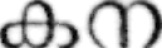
കന
